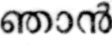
ഞാന്‍
